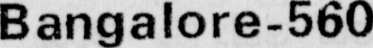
Bangalore-560
